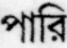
পারি
